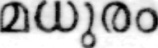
മധുരം
